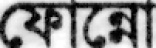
ফোন্নো
